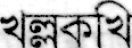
খল্লকখি
